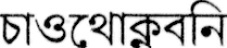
চাওথোক্নবনি
